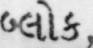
બ્લોક,
